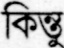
কিন্তু
